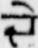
ਦੇ
